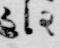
હરિ
